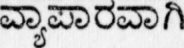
ವ್ಯಾಪಾರವಾಗಿ
